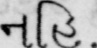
નહિ.
